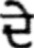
ਦੇ
